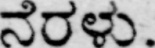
ನೆರಳು.
